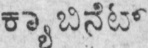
ಕ್ಯಾಬಿನೆಟ್
